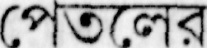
পেতলের
